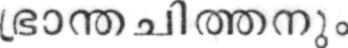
ഭ്രാന്തചിത്തനും
